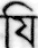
যি
